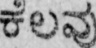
ಕೆಲವು
